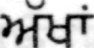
ਅੱਖਾਂ
